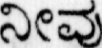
ನೀವು
